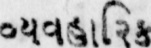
વ્યવહારિક
